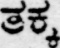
ತಕ್ಕ
